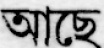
আছে
